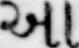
આ
